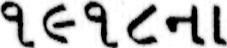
૧૯૧૮ના
